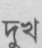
দুখ
